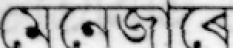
মেনেজাৰে
